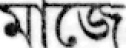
মাজে
